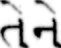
તેને
